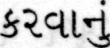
કરવાનું
